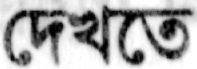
দেখতে
